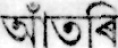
আঁতৰি
